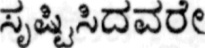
ಸೃಷ್ಟಿಸಿದವರೇ
